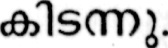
കിടന്നു.
